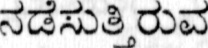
ನಡೆಸುತ್ತಿರುವ
